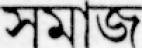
সমাজ
